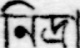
নিদ্রা
